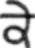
ਕੇ
